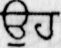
ਉਹ
